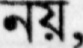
নয়,
